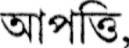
আপত্তি,
